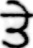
ਤੇ
